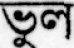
ভুল
